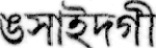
ঙসাইদগী
